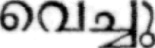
വെച്ചു
